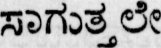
ಸಾಗುತ್ತಲೇ
